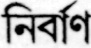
নির্বাণ
